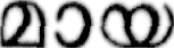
മായ
